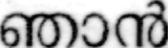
ഞാന്‍
